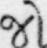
જો
